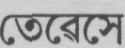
তেৱেসে
